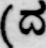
(ದ
